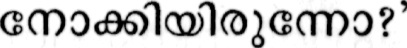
നോക്കിയിരുന്നോ?’
